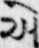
એ
